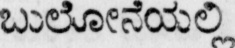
ಬುಲೋನೆಯಲ್ಲಿ
